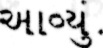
આવ્યું.
